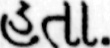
હતા.
